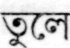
তুলে
